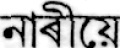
নাৰীয়ে
